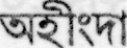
অহীংদা
